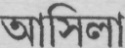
আসিলা
